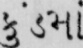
કુંડમાં
